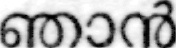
ഞാന്‍
